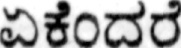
ಏಕೆಂದರೆ
